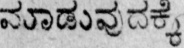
ಮಾಡುವುದಕ್ಕೆ
